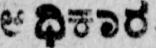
ಅಧಿಕಾರ
